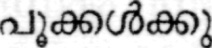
പൂക്കള്‍ക്കു
